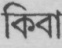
কিবা
